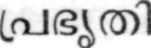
പ്രഭൃതി
